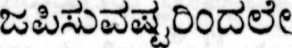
ಜಪಿಸುವಷ್ಟರಿಂದಲೇ
